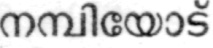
നമ്പിയോട്
